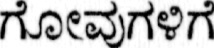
ಗೋವುಗಳಿಗೆ
